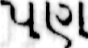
પણ
